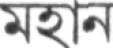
মহান
